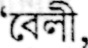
‘বেলী,
